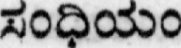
ಸಂಧಿಯಂ
